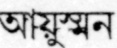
আয়ুস্মন
